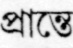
প্রান্তে
